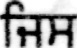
ਜਿਸ
